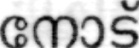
നോട്
